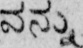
ವನ್ನು
